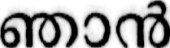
ഞാന്‍
